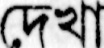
দেখা
